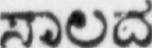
ಸಾಲದ
